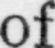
of
